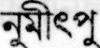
নুমীৎপু
